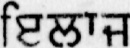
ਇਲਾਜ
